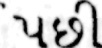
પછી
